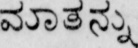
ಮಾತನ್ನು
